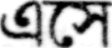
এসে
